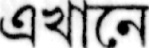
এখানে
